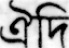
ঐদি
